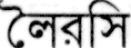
লৈরসি
